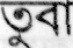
তুবা
